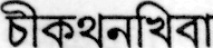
চীকথনখিবা
